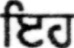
ਇਹ
